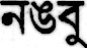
নঙবু
